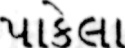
પાકેલા
